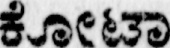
ಕೋಟಾ
